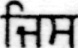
ਜਿਸ
